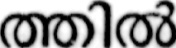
ത്തില്‍
